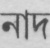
নাদ
